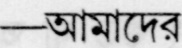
–আমাদের
